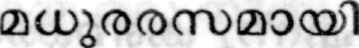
മധുരരസമായി
